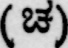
(ಚ)
